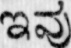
ಇವು
